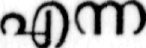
എന്ന
